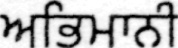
ਅਭਿਮਾਨੀ
